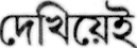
দেখিয়েই
